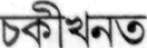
চকীখনত
